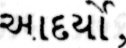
આદર્યો,
